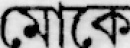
মোকে
